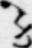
કે
